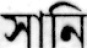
সানি
